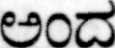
ಅಂದ
